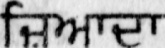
ਜ਼ਿਆਦਾ
